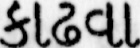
કાઢવા
